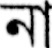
না
